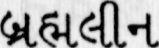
બ્રહ્મલીન
